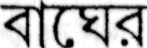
বাঘের
